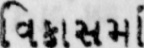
વિકાસમાં
